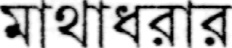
মাথাধরার
